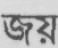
জয়
